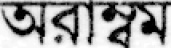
অরাম্বম
